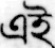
এই
